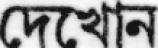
দেখোন
